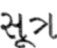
સૂત્ર
